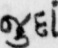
'જુદાં
